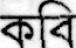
কবি
